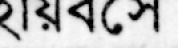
হায়বসে
